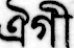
ঐগী
